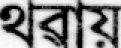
থৱায়
